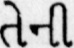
તેની
